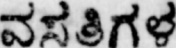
ವಸತಿಗಳ
